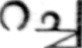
റച്ച
